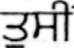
ਤੁਸੀਂ
